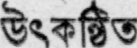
উৎকন্ঠিত
